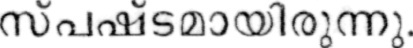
സ്പഷ്ടമായിരുന്നു.
